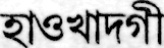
হাওখাদগী
